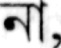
না,
